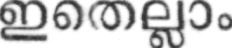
ഇതെല്ലാം
